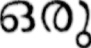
ഒരു
